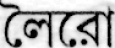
লৈরো
